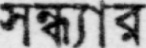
সন্ধ্যার
